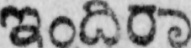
ಇಂದಿರಾ
